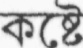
কষ্টে
